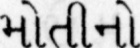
મોતીનો
